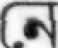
নে
